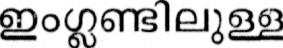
ഇംഗ്ലണ്ടിലുള്ള
